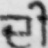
ਦੀ
